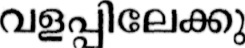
വളപ്പിലേക്കു
